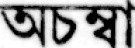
অচম্বা
